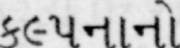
કલ્પનાનો
